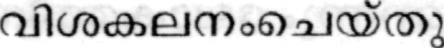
വിശകലനംചെയ്തു
